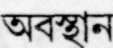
অবস্থান
